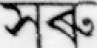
সৰু
